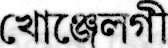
খোঞ্জেলগী
